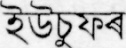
ইউচুফৰ
